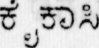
ಕೈಕಾಸಿ
